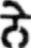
ਨੇ
